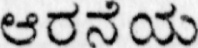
ಆರನೆಯ
